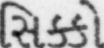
સિક્કો
